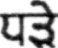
ਧੜੇ
